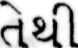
તેથી
